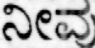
ನೀವು
